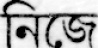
নিজে
